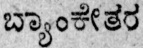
ಬ್ಯಾಂಕೇತರ
